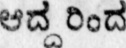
ಆದ್ದರಿಂದ
